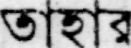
তাহার
